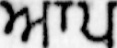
ਆਪ
